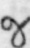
જ
